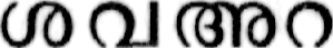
ശവഅറ
